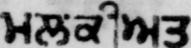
ਮਲਕੀਅਤ
